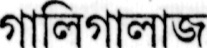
গালিগালাজ
